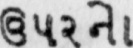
ઉપરનો
